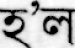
হ'ল
